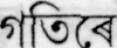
গতিৰে
